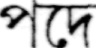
পদে
